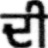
ਦੀ
